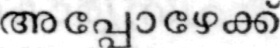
അപ്പോഴേക്ക്
